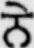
ਨੇ
